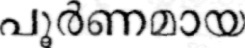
പൂര്‍ണമായ
